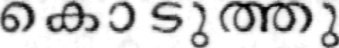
കൊടുത്തു
